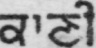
ਕਾਣੀ
